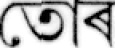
তোৰ
